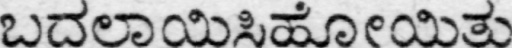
ಬದಲಾಯಿಸಿಹೋಯಿತು
